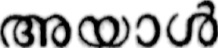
അയാള്‍
